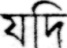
যদি
